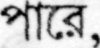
পারে,
